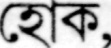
হোক,
